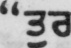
''ਤੁਰ
